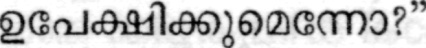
ഉപേക്ഷിക്കുമെന്നോ?”
